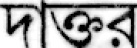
দাক্তর
